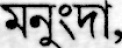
মনুংদা,
